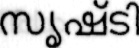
സൃഷ്ടി
